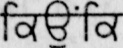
ਕਿਉਂਕਿ
